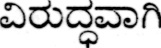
ವಿರುದ್ಧವಾಗಿ
